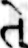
તે
